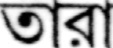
তারা
